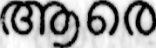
ആരെ
